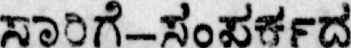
ಸಾರಿಗೆ-ಸಂಪರ್ಕದ
